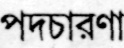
পদচারণা
